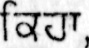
ਕਿਹਾ,
